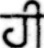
ਹੀ
